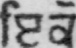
ਇਕੋ
